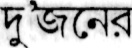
দু'জনের
